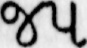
જપ
